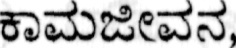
ಕಾಮಜೀವನ,
